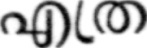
എത്ര
